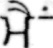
ਮੈਂ
